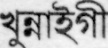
খুন্নাইগী
